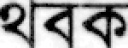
থবক
